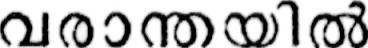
വരാന്തയില്‍
